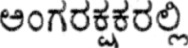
ಅಂಗರಕ್ಷಕರಲ್ಲಿ
